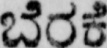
ಬೆರಕೆ
